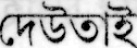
দেউতাই
